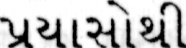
પ્રયાસોથી
